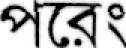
পরেং
